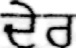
ਦੇਰ
